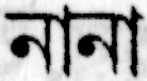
নানা
